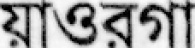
য়াওরগা
